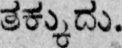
ತಕ್ಕುದು.
